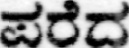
ಪರೆದ
